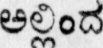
ಅಲ್ಲಿಂದ
